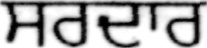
ਸਰਦਾਰ
